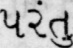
પરંતુ
